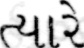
ત્યારે
